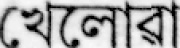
খেলোৱা
